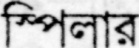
স্পিলার
